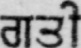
ਗਤੀ
